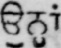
ਉਨ੍ਹਾਂ
